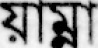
য়াম্না
